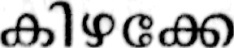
കിഴക്കേ
